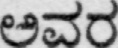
ಅವರ
